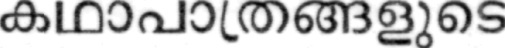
കഥാപാത്രങ്ങളുടെ
